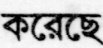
করেছে
